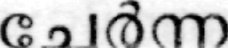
ചേര്‍ന്ന
